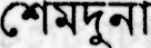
শেমদুনা
